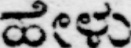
ಹೇಳು
